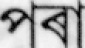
পৰা
